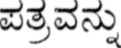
ಪತ್ರವನ್ನು
